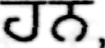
ਹਨ,
